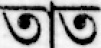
তাত
